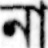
না
